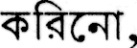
করিনো,
